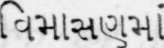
વિમાસણમાં
